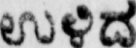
ಉಳಿದ
